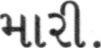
મારી.
